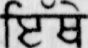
ਇੱਥੇ
